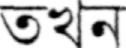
তখন
